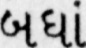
બધાં
